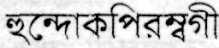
হুন্দোকপিরম্বগী
